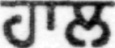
ਹਾਲ
